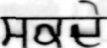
ਸਕਦੇ
